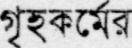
গৃহকর্মের
